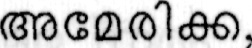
അമേരിക്ക,
